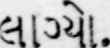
લાગ્યો.
